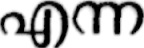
എന്ന
